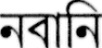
নবানি
